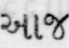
આજ
